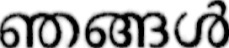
ഞങ്ങള്‍
